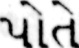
પોતે
